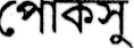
পোকসু
